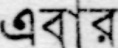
এবার
